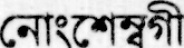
নোংশেম্বগী
